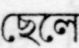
ছেলে
